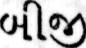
બીજી
